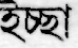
ইচ্ছা
